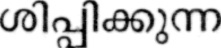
ശിപ്പിക്കുന്ന
